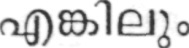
എങ്കിലും
